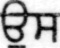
ਉਸ
